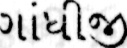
ગાંધીજી
